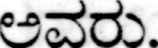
ಅವರು.
